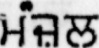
ਮੰਜ਼ਲ
